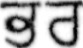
ਭਰ
